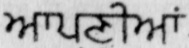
ਆਪਣੀਆਂ
